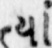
ત્યાં
